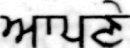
ਆਪਣੇ
